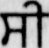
ਸੀ
